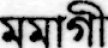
মমাগী
